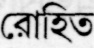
রোহিত
